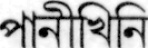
পানীখিনি
